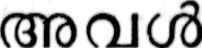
അവള്‍
